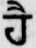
ਹੈ
